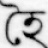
হৈ
